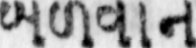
બળવાન
